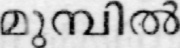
മുമ്പില്‍
